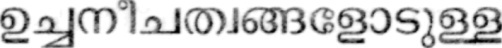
ഉച്ചനീചത്വങ്ങളോടുള്ള
